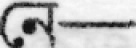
নে-
